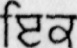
ਇਕ
